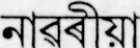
নাৱৰীয়া
